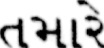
તમારે
